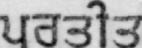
ਪਰਤੀਤ
